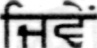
ਜਿਵੇਂ
